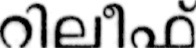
റിലീഫ്
